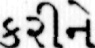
કરીને
